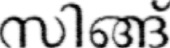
സിങ്ങ്
